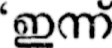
‘ഇന്ന്
